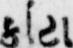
કાંટા
